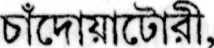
চাঁদোয়াটোরী,
